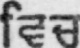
ਵਿਚ
